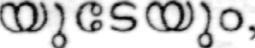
യുടേയും,
